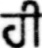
ਹੀ
